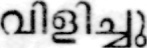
വിളിച്ചു
